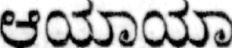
ಆಯಾಯಾ
